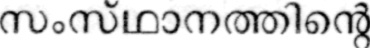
സംസ്ഥാനത്തിന്റെ
